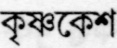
কৃষ্ণকেশ
